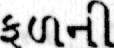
ફળની
